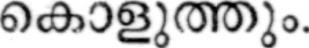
കൊളുത്തും.
